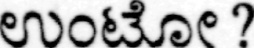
ಉಂಟೋ?
